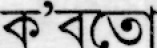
ক'বতো
